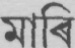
মাৰি
